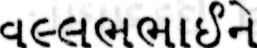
વલ્લભભાઈને
